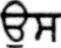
ਉਸ
